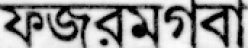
ফজরমগবা
